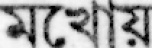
মখোয়
